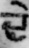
ਦੇ
